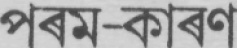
পৰম-কাৰণ
